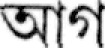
আগ
